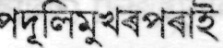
পদূলিমুখৰপৰাই
